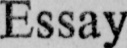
Essay
